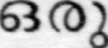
ഒരു
